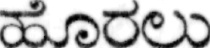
ಹೊರಲು
